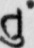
તું
